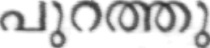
പുറത്തു
